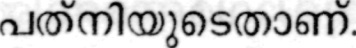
പത്നിയുടെതാണ്.
